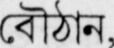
বৌঠান,
